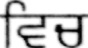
ਵਿਚ
